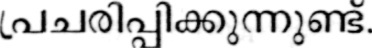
പ്രചരിപ്പിക്കുന്നുണ്ട്.
